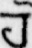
ਹੋ
